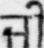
ਜੀ
